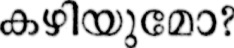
കഴിയുമോ?
